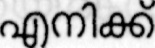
എനിക്ക്
